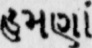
હમણાં
